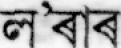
ল'ৰাৰ
